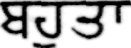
ਬਹੁਤ
